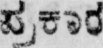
ಪ್ರಕಾರ
